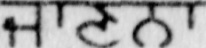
ਜਾਣਨਾ
